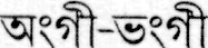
অংগী-ভংগী
